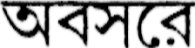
অবসরে
